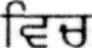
ਵਿਚ
